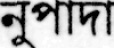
নুপাদা
